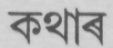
কথাৰ
